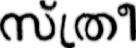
സ്ത്രീ
